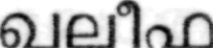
ഖലീഫ
